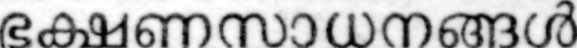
ഭക്ഷണസാധനങ്ങള്‍
